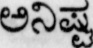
ಅನಿಷ್ಟ
